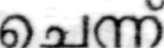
ചെന്ന്
